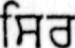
ਸਿਰ
